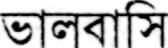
ভালবাসি
